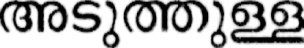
അടുത്തുള്ള
